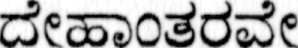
ದೇಹಾಂತರವೇ
